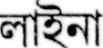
লাইনা
